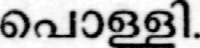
പൊള്ളി.
